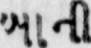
બાની
